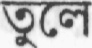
তুলে
